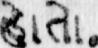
હોતો.
